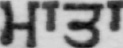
ਮਾਤਾ
